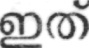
ഇത്
